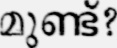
മുണ്ട്?
